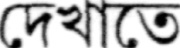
দেখাতে
